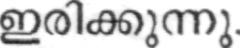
ഇരിക്കുന്നു.
